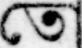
তো
